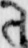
તે
